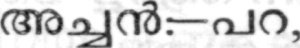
അച്ചന്‍:-പറ,
